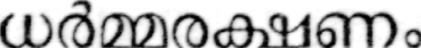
ധര്‍മ്മരക്ഷണം
